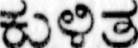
ಕುಳಿತ
